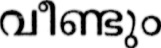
വീണ്ടും
